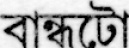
বান্ধটো
